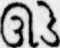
ઊડે
